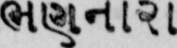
ભણનારા
